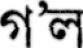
গ'ল
